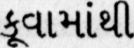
કૂવામાંથી
